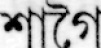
শাগৈ
